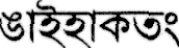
ঙাইহাকতং
